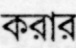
করার
